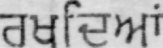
ਰਖਦਿਆਂ
